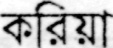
করিয়া
